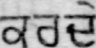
ਕਰਦੇ
